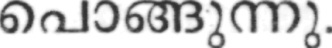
പൊങ്ങുന്നു.
